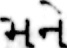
મને
